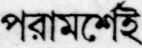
পরামর্শেই
